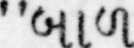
"બાળ
